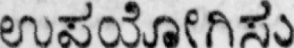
ಉಪಯೋಗಿಸು
